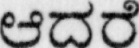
ಆದರೆ
